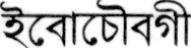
ইবোচৌবগী
